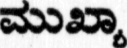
ಮುಖ್ಯಾ
